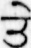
ਤੇ
